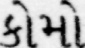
કોમો
